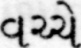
વચ્ચે
